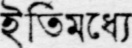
ইতিমধ্যে
